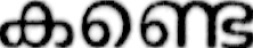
കണ്ടെ
